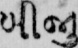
બીજુ
